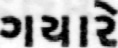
ગયારે
